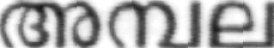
അമ്പല
